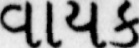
વાયક
